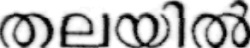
തലയില്‍
